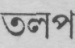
তলপ
